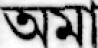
অমা
